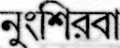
নুংশিরবা
